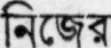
নিজের
